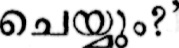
ചെയ്യും?'
